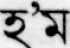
হ'ম
